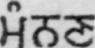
ਮੰਨਣ
